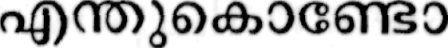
എന്തുകൊണ്ടോ
